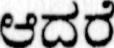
ಆದರೆ
